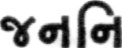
જનનિ
